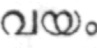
വയം
